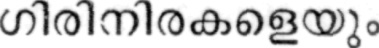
ഗിരിനിരകളെയും
